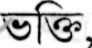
ভক্তি,
